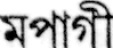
মপাগী
